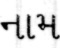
નામ
